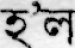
হ'ল
